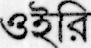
ওইরি
